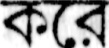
করে
